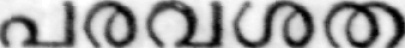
പരവശത
